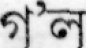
গ'ল
